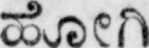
ಹೋಗಿ
